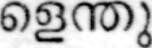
ളെന്തു
